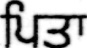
ਪਿਤਾ
